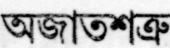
অজাতশত্রু
